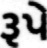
રૂપે
